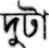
দুটা
